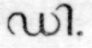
ഡി.
